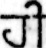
ਹੀ
